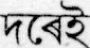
দৰেই
